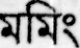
মমিং
